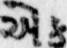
એક
